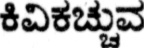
ಕಿವಿಕಚ್ಚುವ
